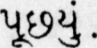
પૂછયું.
